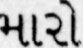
મારો
